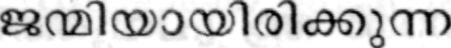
ജന്മിയായിരിക്കുന്ന
